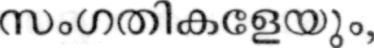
സംഗതികളേയും,
